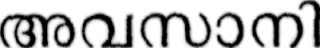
അവസാനി
